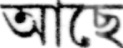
আছে
